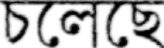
চলেছে
